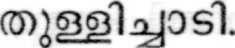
തുള്ളിച്ചാടി.
